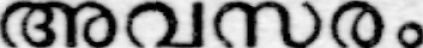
അവസരം
